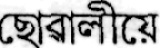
ছোৱালীয়ে
